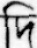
দি
